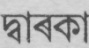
দ্বাৰকা
